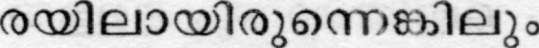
രയിലായിരുന്നെങ്കിലും
